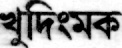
খুদিংমক
